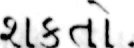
શકતો.
